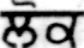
ਲੋਕ
